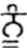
ਨੂੰ
